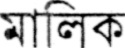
মালিক
